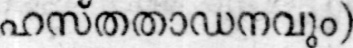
ഹസ്തതാഡനവും)
